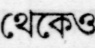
থেকেও
